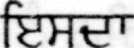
ਇਸਦਾ
